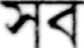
সব
